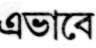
এভাবে
